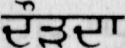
ਦੌੜਦਾ
